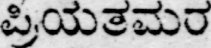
ಪ್ರಿಯತಮರ
